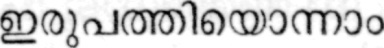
ഇരുപത്തിയൊന്നാം
